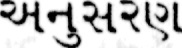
અનુસરણ
